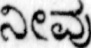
ನೀವು
